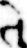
તે
